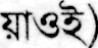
য়াওই)
